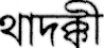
থাদক্কী
